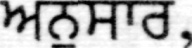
ਅਨੁਸਾਰ,
